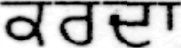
ਕਰਦਾ
